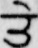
ਤੇ
